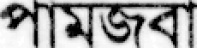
পামজবা
